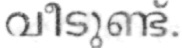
വീടുണ്ട്.
